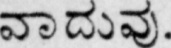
ವಾದುವು.
